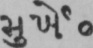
મુર્ખેં.
